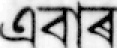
এবাৰ
